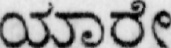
ಯಾರೇ
